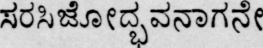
ಸರಸಿಜೋದ್ಭವನಾಗನೇ
